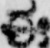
ಈ
